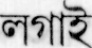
লগাই
